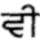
ਵੀ
